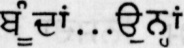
ਬੂੰਦਾਂ........ਉਨ੍ਹਾਂ
